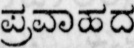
ಪ್ರವಾಹದ
